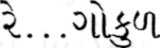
રે...ગોકુળ
